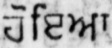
ਹੋਇਆ
